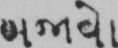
બજાવો
